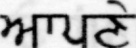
ਆਪਣੇ
